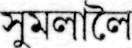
সুমলালৈ
